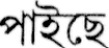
পাইছে
